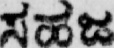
ಸಹಜ
